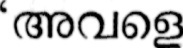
‘അവളെ
